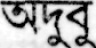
অদুবু
